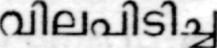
വിലപിടിച്ച
